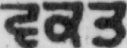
ਵਕਤ
